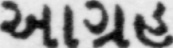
આગ્રહ
